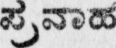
ಪ್ರವಾಹ
